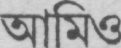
আমিও
